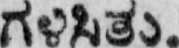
ಗಳಿಸಿತು.
